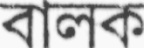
বালক
